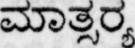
ಮಾತ್ಸರ್‍ಯ
